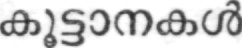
കൂട്ടാനകള്‍
